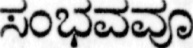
ಸಂಭವವೂ
